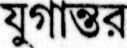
যুগান্তর
